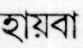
হায়বা
